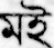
মই
